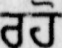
ਰਹੋ
